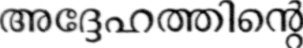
അദ്ദേഹത്തിന്റെ
